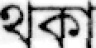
থকা
